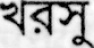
খরসু
